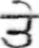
ਤੇ
